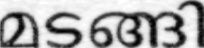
മടങ്ങി
